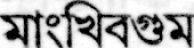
মাংখিবগুম
